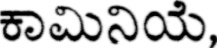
ಕಾಮಿನಿಯೆ,
